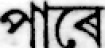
পাৰে
